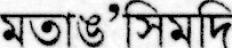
মতাঙ’সিমদি
